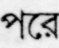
পরে
